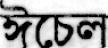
ঈচেল
